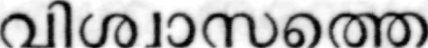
വിശ്വാസത്തെ
